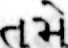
તમે
